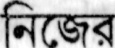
নিজের
